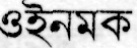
ওইনমক
